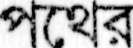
পথের
